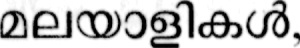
മലയാളികള്‍,
